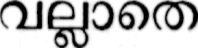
വല്ലാതെ
